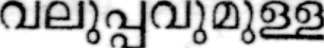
വലുപ്പവുമുള്ള
